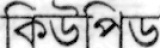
কিউপিড
